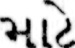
માટે
